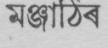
মঞ্জাঠিৰ
